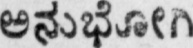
ಅನುಭೋಗಿ
